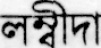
লম্বীদা
